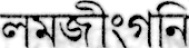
লমজীংগনি
